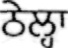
ਠੇਲ੍ਹਾ
